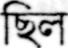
ছিল
